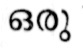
ഒരു
